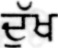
ਦੁੁੱਖ
